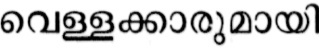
വെള്ളക്കാരുമായി
